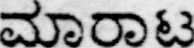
ಮಾರಾಟ
